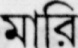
মারি
